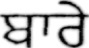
ਬਾਰੇ
